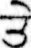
ਤੇ
